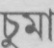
চুমা
